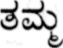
ತಮ್ಮ
